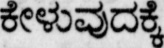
ಕೇಳುವುದಕ್ಕೆ
